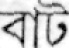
বাট
